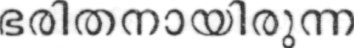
ഭരിതനായിരുന്ന
